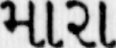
મારા
